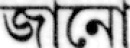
জানো
